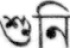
শুনি
